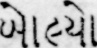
બોલ્યો
